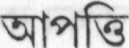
আপত্তি
